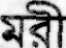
মরী
